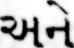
અને
